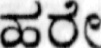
ಹರೇ
